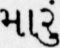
મારું
